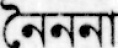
নৈননা
